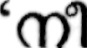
‘നീ
